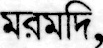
মরমদি,
